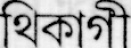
থিকাগী
